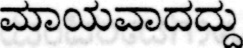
ಮಾಯವಾದದ್ದು
